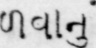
ળવાનું
